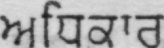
ਅਧਿਕਾਰ
